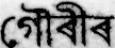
গৌৰীৰ
